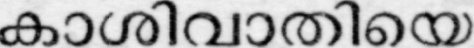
കാശിവാതിയെ
